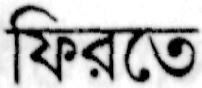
ফিরতে
